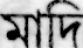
মাদি
